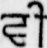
ਵੀ
